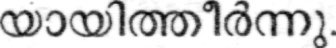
യായിത്തീര്‍ന്നു.
